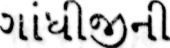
ગાંધીજીની
